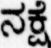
ನಕ್ಷೆ
